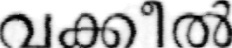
വക്കീല്‍
